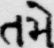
તમે
